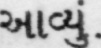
આવ્યું.
